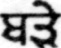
ਬੜੇ
